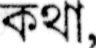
কথা,
